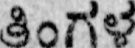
ತಿಂಗಳ
